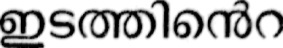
ഇടത്തിന്റെ
